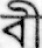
বী
